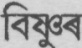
বিষ্ণুৰ
